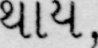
થાય,
